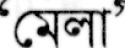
‘মেলা’
